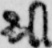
શ્રી
